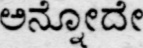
ಅನ್ನೋದೇ
